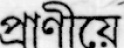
প্রাণীয়ে
